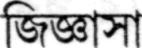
জিজ্ঞাসা
